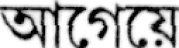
আগেয়ে
